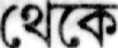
থেকে
